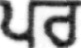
ਪਰ
